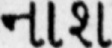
નાશ
